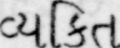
વ્યક્તિ
